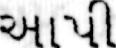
આપી
